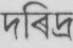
দৰিদ্ৰ
